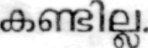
കണ്ടില്ല.
